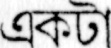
একটা
